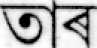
তাৰ
